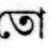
তো
